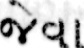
જેવા
